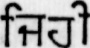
ਜਿਹੀ
